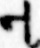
ન
